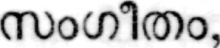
സംഗീതം,
